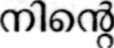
നിന്റെ
